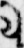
યે
